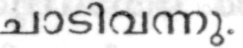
ചാടിവന്നു.
